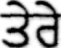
ਤੇਰੇ
